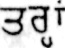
ਤਰ੍ਹਾਂ
